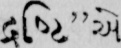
દ્રષ્ટિ”એ
